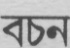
বচন
